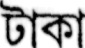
টাকা
